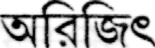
অরিজিৎ
